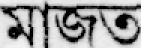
মাজত
